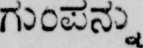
ಗುಂಪನ್ನು
